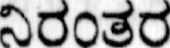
ನಿರಂತರ
